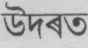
উদৰত
